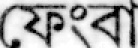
ফেংবা
